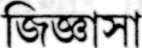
জিজ্ঞাসা
